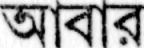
আবার
